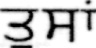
ਤੁਸਾਂ
